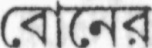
বোনের
